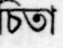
চিতা
